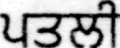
ਪਤਲੀ
